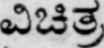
ವಿಚಿತ್ರ
